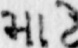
માટે
